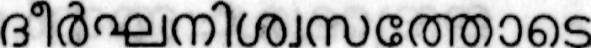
ദീര്‍ഘനിശ്വസത്തോടെ
